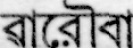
ৱারৌবা
